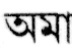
অমা
